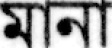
মানা
